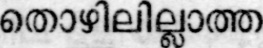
തൊഴിലില്ലാത്ത
